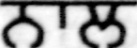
ਨਾਲ
